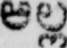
ಆಲ್ಲ
